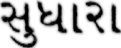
સુધારા
